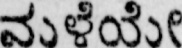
ಮಳೆಯೇ
